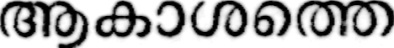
ആകാശത്തെ
